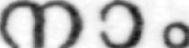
നാം
